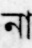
না
